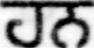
ਹਨ
